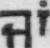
ਜਾਂ
